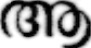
ആ
